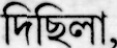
দিছিলা,
